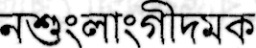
নশুংলাংগীদমক
